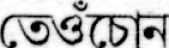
তেওঁচোন
